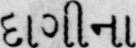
દાગીના
